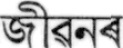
জীৱনৰ
